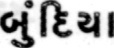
બુંદિયા
